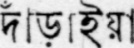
দাঁড়াইয়া
